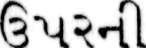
ઉપરની
